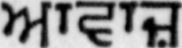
ਆਵਾਜ਼
